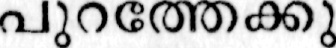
പുറത്തേക്കു
